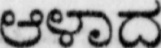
ಆಳಾದ
